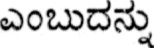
ಎಂಬುದನ್ನು
